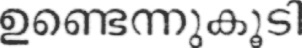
ഉണ്ടെന്നുകൂടി
